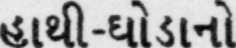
હાથી-ઘોડાનો
